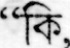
"কি,
